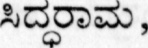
ಸಿದ್ಧರಾಮ,
